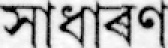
সাধাৰণ
